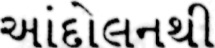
આંદોલનથી
